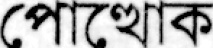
পোত্থোক
